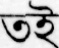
তই
